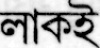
লাকই
